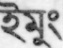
ইমুং
